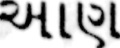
આણ
